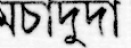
মচাদুদা
